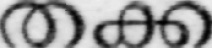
തക്ക
